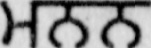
ਮਨਨ
